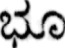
ಭೂ
